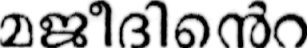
മജീദിന്റെ
